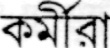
কর্মীরা
